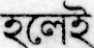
হলেই
